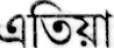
এতিয়া
